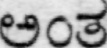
ಅಂತ
